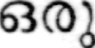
ഒരു
